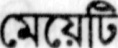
মেয়েটি
